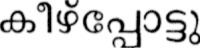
കീഴ്പ്പോട്ടു
